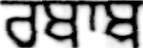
ਰਬਾਬ
